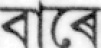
বাৰে
